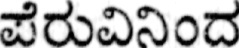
ಪೆರುವಿನಿಂದ
